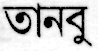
তানবু
